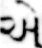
એ
